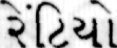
રેંટિયો
